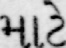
માટે
